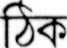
ঠিক
